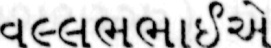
વલ્લભભાઈએ
